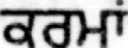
ਕਰਮਾਂ
